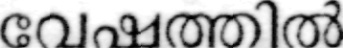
വേഷത്തില്‍
